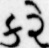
કરે
